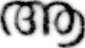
ആ
